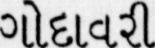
ગોદાવરી
